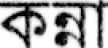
কন্না
